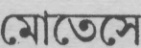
মোতেসে
